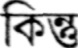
কিন্তু
